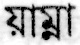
য়াম্না
